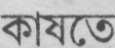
কাষতে
